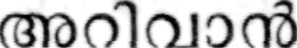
അറിവാന്‍
